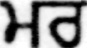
ਮਰ
